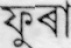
ফুৰা
